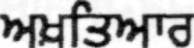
ਅਖ਼ਤਿਆਰ
